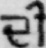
ਦੀ
